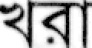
খরা
